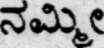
ನಮ್ಮೀ
